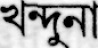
খন্দুনা
